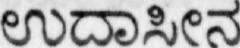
ಉದಾಸೀನ
